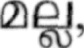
മല്ല,
